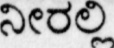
ನೀರಲ್ಲಿ
